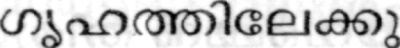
ഗൃഹത്തിലേക്കു
